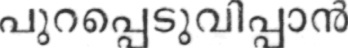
പുറപ്പെടുവിപ്പാന്‍
